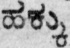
ಹಕ್ಕು
